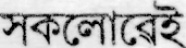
সকলোৱেই
